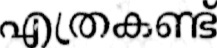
എത്രകണ്ട്
